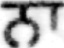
ਨਾ
